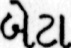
બેટા
